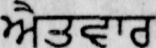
ਐਤਵਾਰ
